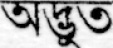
অদ্ভুত
